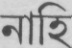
নাহি
